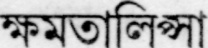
ক্ষমতালিপ্সা
